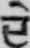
ਦੇ
